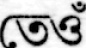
তেওঁ
